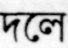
দলে
